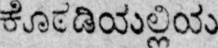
ಕೊಠಡಿಯಲ್ಲಿಯ
